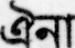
ঐনা
